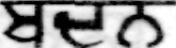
ਬਦਨ
